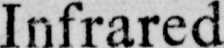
Infrared
